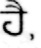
ਹੈ,
